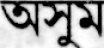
অসুম
